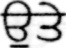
ਉਤੇ
